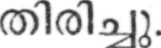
തിരിച്ചു.
